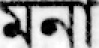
মনা
